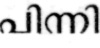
പിന്നി
